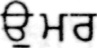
ਉਮਰ
